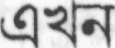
এখন
